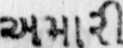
અમારી
